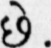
છે.
